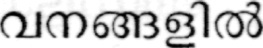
വനങ്ങളില്‍
